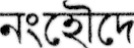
নংহৌদে
